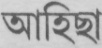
আহিছা
